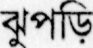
ঝুপড়ি
